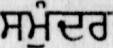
ਸਮੁੰਦਰ
